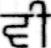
ਵੀ
